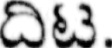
ದಿಟ.
